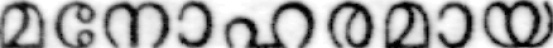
മനോഹരമായ
